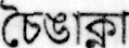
চৈঙাক্না
